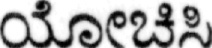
ಯೋಚಿಸಿ
